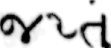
જપ્ત
